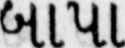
બાપા
